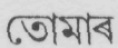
তোমাৰ
